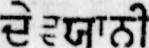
ਦੇਵਯਾਨੀ
